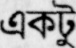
একটু
